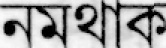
নমথাক
